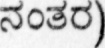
ನಂತರ)
